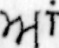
ਆਂ
